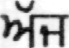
ਅੱਜ
